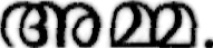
അമ്മ.
